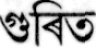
গুৰিত
